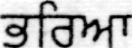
ਭਰਿਆ
